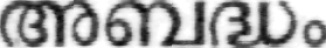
അബദ്ധം
